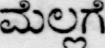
ಮೆಲ್ಲಗೆ
